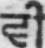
ਵੀ
